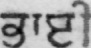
ਭਾਈ
